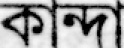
কান্দা
